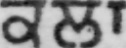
ਕਲਾ
